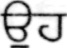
ਉਹ
